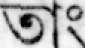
তাং
